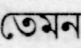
তেমন
